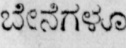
ಬೇನೆಗಳೂ
